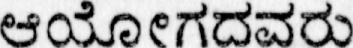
ಆಯೋಗದವರು
